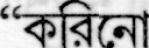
“করিনো
